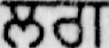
ਲਗ
